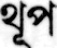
থূপ
